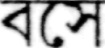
বসে
